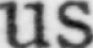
us
